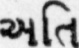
અતિ
